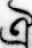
ঐ
